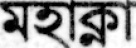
মহাক্না
